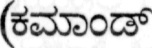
(ಕಮಾಂಡ್
